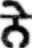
ਨੇ
